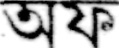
অফ
